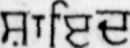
ਸ਼ਾਇਦ
